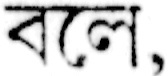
বলে,
